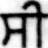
ਸੀ
